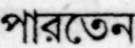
পারতেন
